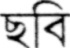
ছবি
